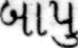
બાપુ
